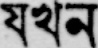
যখন
